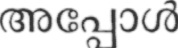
അപ്പോള്‍
